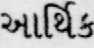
આર્થિક
